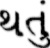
થતું
